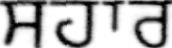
ਸਹਾਰ
